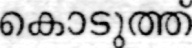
കൊടുത്ത്
